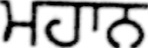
ਮਹਾਨ
